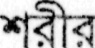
শরীর
